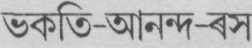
ভকতি-আনন্দ-ৰস
